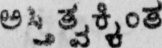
ಅಸ್ತಿತ್ವಕ್ಕಿಂತ
